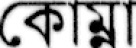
কোম্না
